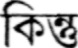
কিন্তু
